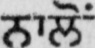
ਨਾਲੋਂ
